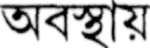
অবস্থায়
